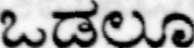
ಒಡಲೂ
